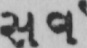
સર્વ
